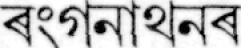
ৰংগনাথনৰ
